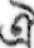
ঐ
